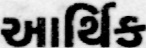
આર્થિક
